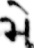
મે
